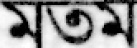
মতম
